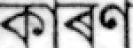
কাৰণ
